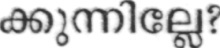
ക്കുന്നില്ലേ?
